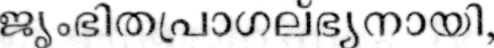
ജൃംഭിതപ്രാഗല്ഭ്യനായി,
